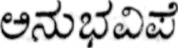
ಅನುಭವಿಪೆ
